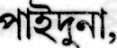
পাইদুনা,
